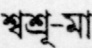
শ্বশ্রূ-মা
